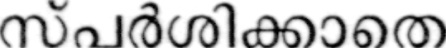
സ്പര്‍ശിക്കാതെ
